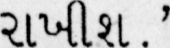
રાખીશ.'
